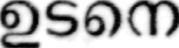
ഉടനെ
